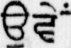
ਉਵੇਂ
